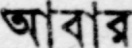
আবার
